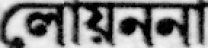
লোয়ননা
